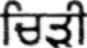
ਚਿੜੀ
